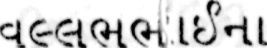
વલ્લભભાઈના
